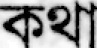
কথা
